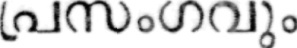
പ്രസംഗവും
